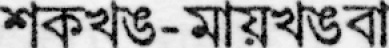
শকখঙ-মায়খঙবা
